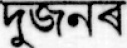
দুজনৰ
